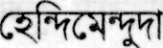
হেন্দিমেন্দুদা
